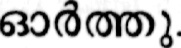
ഓര്‍ത്തു.
